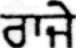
ਰਾਜੇ
